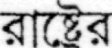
রাষ্ট্রের
